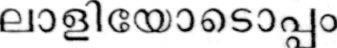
ലാളിയോടൊപ്പം
